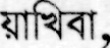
য়াখিবা,
